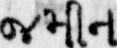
જમીન
